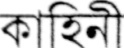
কাহিনী
